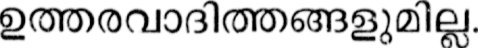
ഉത്തരവാദിത്തങ്ങളുമില്ല.
